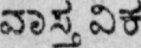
ವಾಸ್ತವಿಕ
